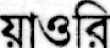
য়াওরি
